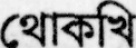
থোকখি
